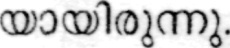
യായിരുന്നു.
